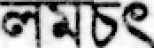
লমচৎ
